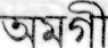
অমগী
